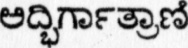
ಅದ್ಭಿರ್ಗಾತ್ರಾಣಿ
